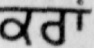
ਕਰਾਂ
